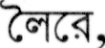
লৈরে,
